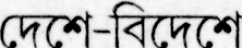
দেশে-বিদেশে
